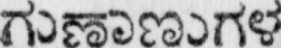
ಗುಣಾಣುಗಳ
